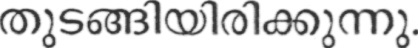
തുടങ്ങിയിരിക്കുന്നു.
